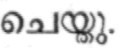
ചെയ്തു.
